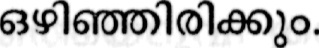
ഒഴിഞ്ഞിരിക്കും.
